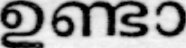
ഉണ്ടാ
